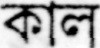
কাল
